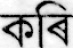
কৰি
